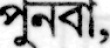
পুনবা,
